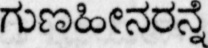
ಗುಣಹೀನರನ್ನೆ
